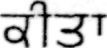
ਕੀਤਾ
